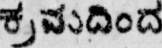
ಕ್ರಮದಿಂದ
